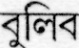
বুলিব
